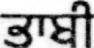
ਭਾਬੀ
